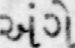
અંગે
